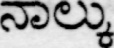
ನಾಲ್ಕು
